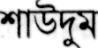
শাউদুম
